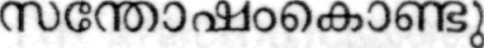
സന്തോഷംകൊണ്ടു
